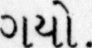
ગયો.
